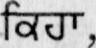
ਕਿਹਾ,
